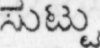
ಸುಟ್ಟು
